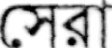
সেরা
